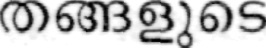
തങ്ങളുടെ
